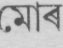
মোৰ
